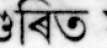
শুৰিত
